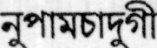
নুপামচাদুগী
